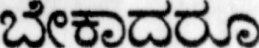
ಬೇಕಾದರೂ
